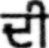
ਦੀ
